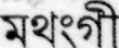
মথংগী
